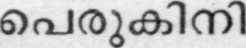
പെരുകിനി
